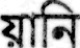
য়ানি
